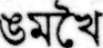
ঙমখৈ
